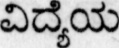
ವಿದ್ಯೆಯ
